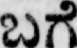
ಬಗೆ
